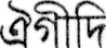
ঐগীদি
